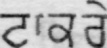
ਟਾਕਰੇ
